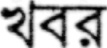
খবর
